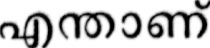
എന്താണ്
